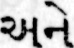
અને
